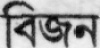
বিজন
